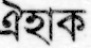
ঐহাক
